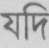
যদি
